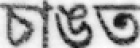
চাঙত
